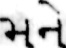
મને
